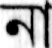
না
